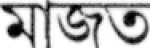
মাজত
